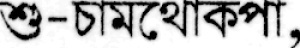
শু-চামথোকপা,
